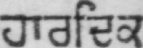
ਹਾਰਦਿਕ
